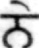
ਨੇ
